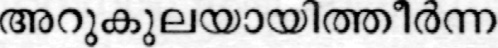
അറുകുലയായിത്തീര്‍ന്ന
